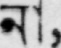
না,
